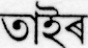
তাইৰ
